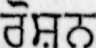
ਰੋਸ਼ਨ
